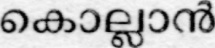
കൊല്ലാന്‍
